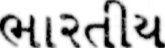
ભારતીય
